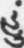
હું
